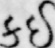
કઈ
